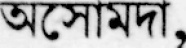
অসোমদা,
